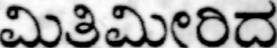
ಮಿತಿಮೀರಿದ
